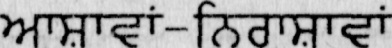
ਆਸ਼ਾਵਾਂ-ਨਿਰਾਸ਼ਾਵਾਂ
